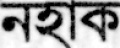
নহাক
